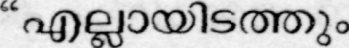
"എല്ലായിടത്തും
